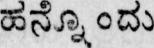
ಹನ್ನೊಂದು
